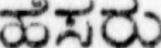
ಹೆಸರು
